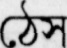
ঠেস
